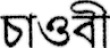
চাওবী
